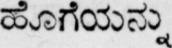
ಹೊಗೆಯನ್ನು
